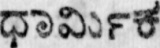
ಧಾರ್ಮಿಕ
